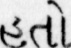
હતો
